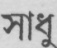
সাধু
